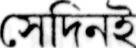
সেদিনই
